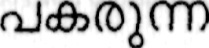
പകരുന്ന
